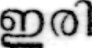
ഇരി
